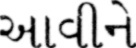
આવીને
